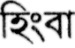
হিংবা
